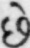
છે
